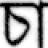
চা
